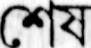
শেষ
